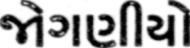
જોગણીયો
